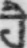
ਹੈ
